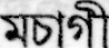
মচাগী
